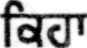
ਕਿਹਾ
